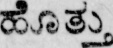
ಹೊತ್ತು
